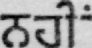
ਨਹੀਂ
